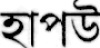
হাপউ
